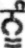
ਨੂੰ
